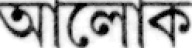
আলোক
